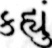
કહ્યું
